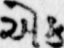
એક
